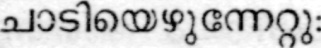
ചാടിയെഴുന്നേറ്റു:
